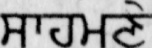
ਸਾਹਮਣੇ
